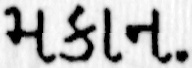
મકાન.
